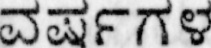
ವರ್ಷಗಳ
